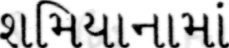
શમિયાનામાં
